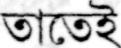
তাতেই
